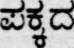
ಪಕ್ಕದ
